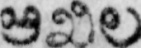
ಅಖಿಲ
